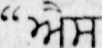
''ਐਸ
